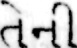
તેની
